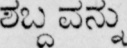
ಶಬ್ದವನ್ನು
